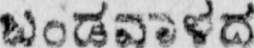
ಬಂಡವಾಳದ
